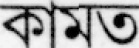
কামত
